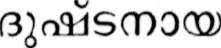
ദുഷ്ടനായ
